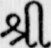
શ્રી
